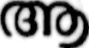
ആ
